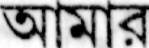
আমার
